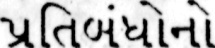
પ્રતિબંધોનો
